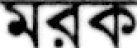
মরক
